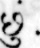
છું.
